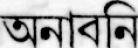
অনাবনি
